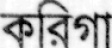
করিগা
